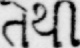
તેથી
